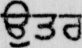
ਉਤਰ
